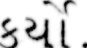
કર્યો.
